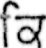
ਕਿ
